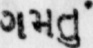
ગમતું
